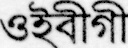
ওইবীগী
